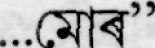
...মোৰ"
